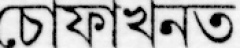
চোফাখনত
